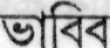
ভাবিব
